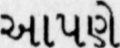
આપણે
